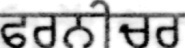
ਫਰਨੀਚਰ
